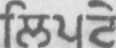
ਲਿਪਟੇ
